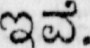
ಇವೆ.
